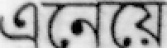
এনেয়ে
